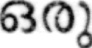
ഒരു
